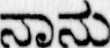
ನಾನು
